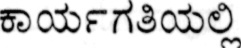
ಕಾರ್ಯಗತಿಯಲ್ಲಿ
